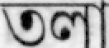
তলা
